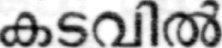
കടവില്‍
